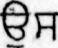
ਉਸ
